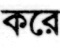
করে
